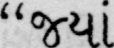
"જ્યાં
